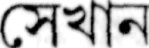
সেখান
